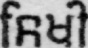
ਸਿਖੀ
